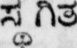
ಸ್ಥಗಿತ
